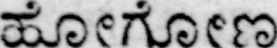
ಹೋಗೋಣ
